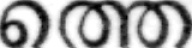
ത്തെ
